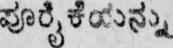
ಪೂರೈಕೆಯನ್ನು
